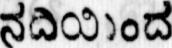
ನದಿಯಿಂದ
